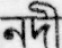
নদী
